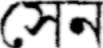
সেন
